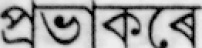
প্রভাকৰে
